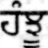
ਹੰਝੂ
